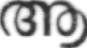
ആ
